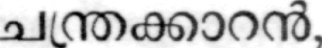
ചന്ത്രക്കാറന്‍,
